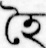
হৈ
